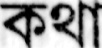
কথা
